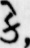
કે,
